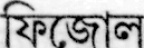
ফিজোল
